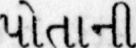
પોતાની
